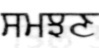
ਸਮਝਣ
